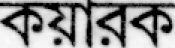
কয়ারক
